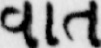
વાત
